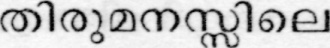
തിരുമനസ്സിലെ
